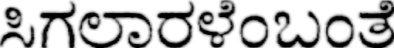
ಸಿಗಲಾರಳೆಂಬಂತೆ
